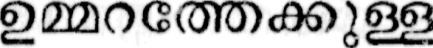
ഉമ്മറത്തേക്കുള്ള
